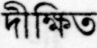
দীক্ষিত
